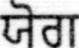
ਯੋਗ
